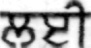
ਲਈ
